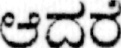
ಆದರೆ
